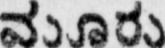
ಮೂರು
